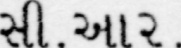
સી..આર.
